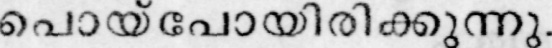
പൊയ്പോയിരിക്കുന്നു.
